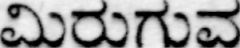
ಮಿರುಗುವ
